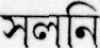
সলনি
